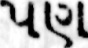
પણ
